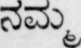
ನಮ್ಮ
